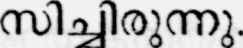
സിച്ചിരുന്നു.
